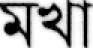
মখা
